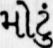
મોટું
